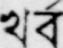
খর্ব
